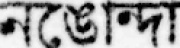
নঙোন্দা
